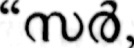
“സര്‍,
